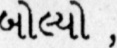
બોલ્યો,
